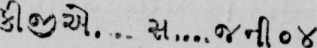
કીજીએ...સ....જની.૪
